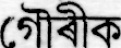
গৌৰীক
